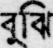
বুঝি
